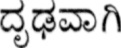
ದೃಧವಾಗಿ
